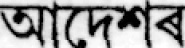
আদেশৰ
